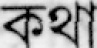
কথা
